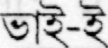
ভাই-ই
